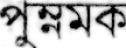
পুম্নমক
